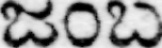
ಜಂಬ
